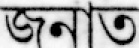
জনাত
